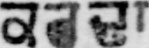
ਕਰਦਾ
